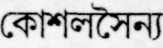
কোশলসৈন্য
